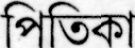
পিতিকা
